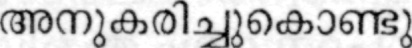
അനുകരിച്ചുകൊണ്ടു
